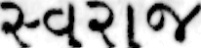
સ્વરાજ
